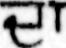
ਦਾ
